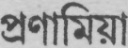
প্ৰণামিয়া
